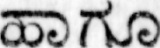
ಹಾಗೂ
